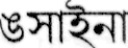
ঙসাইনা
